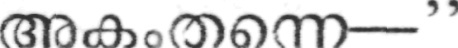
അകംതന്നെ-"
